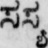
ಸಸ್ಯ
